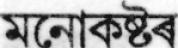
মনোকষ্টৰ
